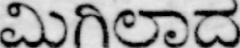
ಮಿಗಿಲಾದ
